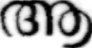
ആ
